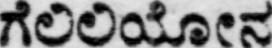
ಗೆಲಿಲಿಯೋನ
